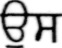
ਉਸ
